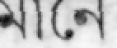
মানে
